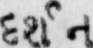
દર્શન
